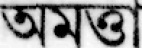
অমত্তা
